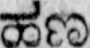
ಹಣ
